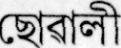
ছোৱালী
